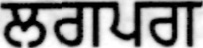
ਲਗਪਗ
